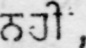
ਨਹੀਂ,
